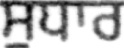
ਸੁਧਾਰ
